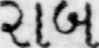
રાબ
